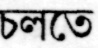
চলতে
